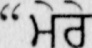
''ਮੇਰੇ
